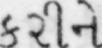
કરીને
